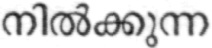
നില്‍ക്കുന്ന
